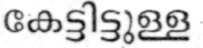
കേട്ടിട്ടുള്ള
